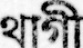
থাগী
